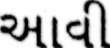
આવી
